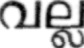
വല്ല
